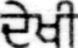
ਦੇਖੀ
